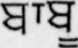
ਬਾਬੂ
